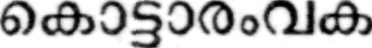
കൊട്ടാരംവക
